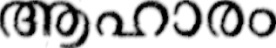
ആഹാരം
